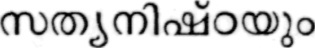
സത്യനിഷ്ഠയും
